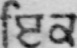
ਇਕ
